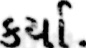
કર્યા.
